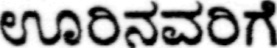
ಊರಿನವರಿಗೆ
